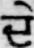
ਦੇ
